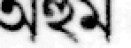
অহুম
